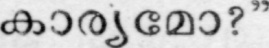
കാര്യമോ?"
